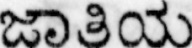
ಜಾತಿಯ
